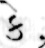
કે,
